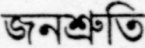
জনশ্রুতি
